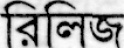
রিলিজ
